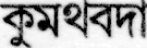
কুমথবদা
